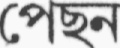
পেছন
